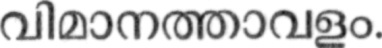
വിമാനത്താവളം.
